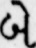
બે
